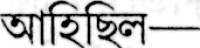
আহিছিল-
